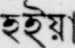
হইয়া
